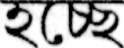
হচ্ছে
